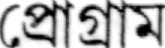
প্রোগ্রাম
